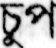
চুপ
